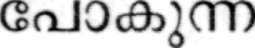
പോകുന്ന
